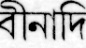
বীনাদি
